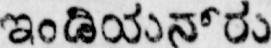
ಇಂಡಿಯನ್‌ರು
